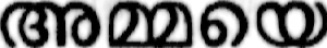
അമ്മയെ
